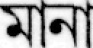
মানা
